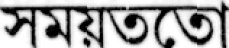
সময়ততো
